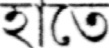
হাতে
